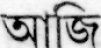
আজি
